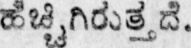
ಹೆಚ್ಚಿಗಿರುತ್ತದೆ.
